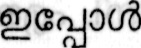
ഇപ്പോള്‍
